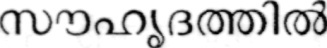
സൌഹൃദത്തില്‍
